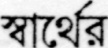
স্বার্থের
